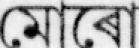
মোৰো
